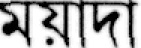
ময়াদা
